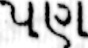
પણ
